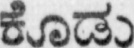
ಕೊಡು
